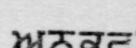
ਅਨਰਵ
